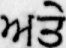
ਅਤੇ
